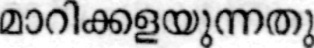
മാറിക്കളയുന്നതു
